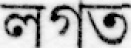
লগত
